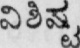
ವಿಶಿಷ್ಟ
